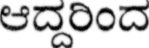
ಆದ್ದರಿಂದ
